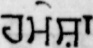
ਹਮੇਸ਼ਾ
